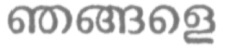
ഞങ്ങളെ
